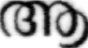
ആ
